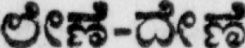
ಲೇಣೆ-ದೇಣೆ
